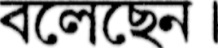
বলেছেন।
